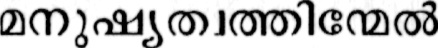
മനുഷ്യത്വത്തിന്മേല്‍
